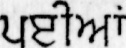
ਪਈਆਂ
